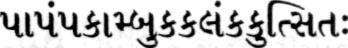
પાપંપકામ્બકકલંકકુત્સિતઃ
